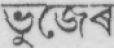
ভুজেৰ
